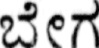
ಬೇಗ
